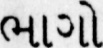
ભાગો
